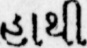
હાથી
